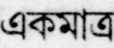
একমাত্র
